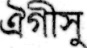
ঐগীসু
